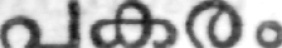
പകരം
